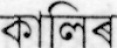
কালিৰ
